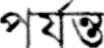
পর্যন্ত
